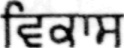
ਵਿਕਾਸ
